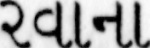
રવાના
